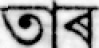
তাৰ
